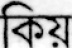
কিয়
